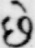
છે
